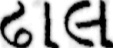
ઢાલ
